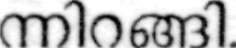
ന്നിറങ്ങി.
